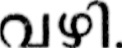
വഴി.
